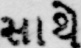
સાથે
